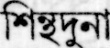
শিন্থদুনা
